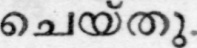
ചെയ്തു.
